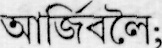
আর্জিবলৈ;
